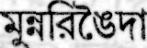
মুন্নরিঙৈদা
